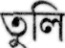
তুলি
